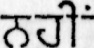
ਨਹੀਂ
